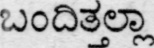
ಬಂದಿತ್ತಲ್ಲಾ
